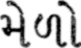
મેળો
